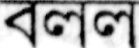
বলল
